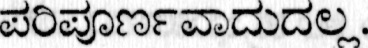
ಪರಿಪೂರ್ಣವಾದುದಲ್ಲ.
